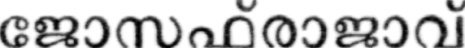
ജോസഫ്രാജാവ്
